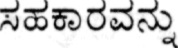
ಸಹಕಾರವನ್ನು
